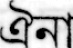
ঐনা
